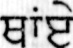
ਥਾਂਏ
